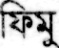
ফিমু
